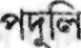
পদুলি
